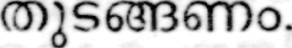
തുടങ്ങണം.
